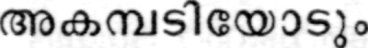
അകമ്പടിയോടും
